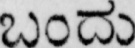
ಬಂದು
